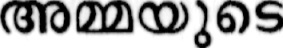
അമ്മയുടെ
